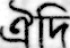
ঐদি
